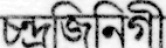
চন্দ্রজিনিগী
